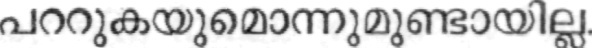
പററുകയുമൊന്നുമുണ്ടായില്ല.
